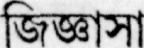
জিজ্ঞাসা
